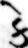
કે
